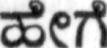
ಹೇಗೆ
